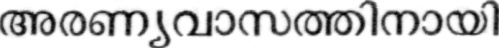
അരണ്യവാസത്തിനായി
